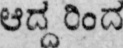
ಆದ್ದರಿಂದ
